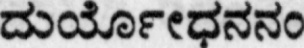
ದುರ್ಯೋಧನನಂ
